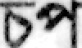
চপ
